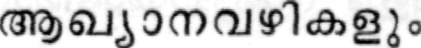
ആഖ്യാനവഴികളും
